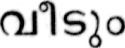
വീടും
